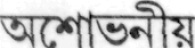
অশোভনীয়
